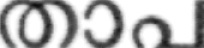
താപ
